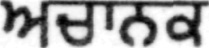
ਅਚਾਨਕ
